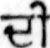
ਦੀ
